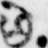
છે.
